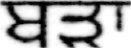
ਬੜਾ
